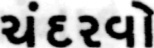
ચંદરવો
